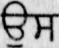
ਉਸ
